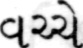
વચ્ચે
